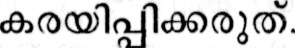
കരയിപ്പിക്കരുത്.
